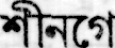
শীনগে
